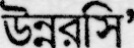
উন্নরসি’
